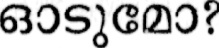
ഓടുമോ?
